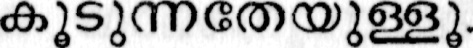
കൂടുന്നതേയുള്ളൂ.
